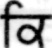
ਕਿ
